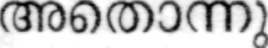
അതൊന്നു
